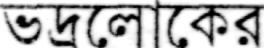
ভদ্রলোকের
